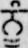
ਨੂੰ
